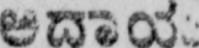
ಆದಾಯ
